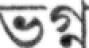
ভগ্ন
